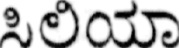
ಸಿಲಿಯಾ
